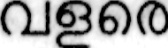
വളരെ
